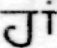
ਹਾਂ
